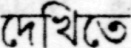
দেখিতে
